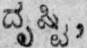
ದೃಷ್ಟಿ,
